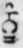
ਨੂੰ
